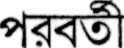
পরবর্তী
